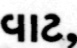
વાટ,
